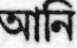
আনি
